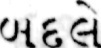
બદલે
